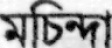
মচিন্দা
